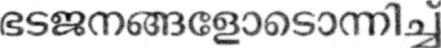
ഭടജനങ്ങളോടൊന്നിച്ച്
